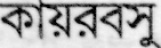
কায়রবসু
